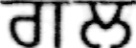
ਗਲ
